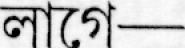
লাগে-
